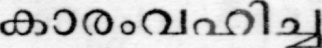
കാരംവഹിച്ച
